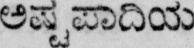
ಅಷ್ಟಪಾದಿಯ
